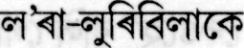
ল'ৰা-লুৰিবিলাকে
